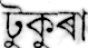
টুকুৰা
